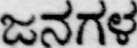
ಜನಗಳ
